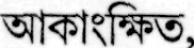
আকাংক্ষিত,
